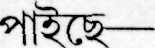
পাইছে-
